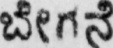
ಬೇಗನೆ
